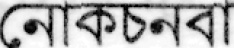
নোকচনবা
